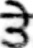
ਤੇ
